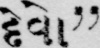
દેવો”
